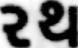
રથ
